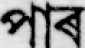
পাৰ
